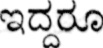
ಇದ್ದರೂ
